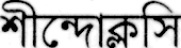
শীন্দোক্লসি
